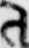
તે
